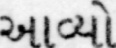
આવ્યો
